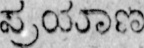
ಪ್ರಯಾಣ
